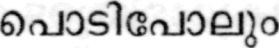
പൊടിപോലും
